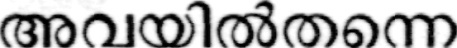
അവയില്‍തന്നെ
